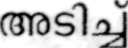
അടിച്ച്
